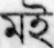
মই
